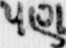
પણ
